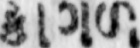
કાગળ
